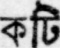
কটি
